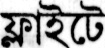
ফ্লাইটে
